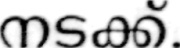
നടക്ക്.
